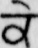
ਕੇ
